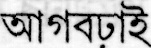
আগবঢ়াই
